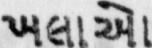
ખલાઓ
